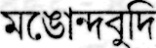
মঙোন্দবুদি
